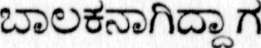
ಬಾಲಕನಾಗಿದ್ದಾಗ
